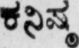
ಕನಿಷ್ಠ
